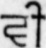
ਵੀ
